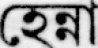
হেন্না
